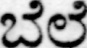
ಬೆಲೆ
